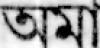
অমা
